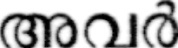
അവര്‍
